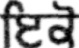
ਇਕੋ
